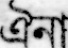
ঐনা
